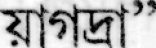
য়াগদ্রা”
